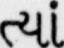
ત્યાં
